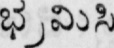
ಭ್ರಮಿಸಿ
